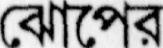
ঝোপের
